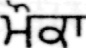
ਮੌਕਾ
